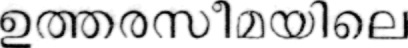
ഉത്തരസീമയിലെ
